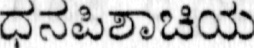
ಧನಪಿಶಾಚಿಯ
